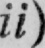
ii)
